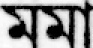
মমা
